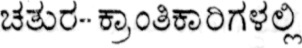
ಚತುರ-ಕ್ರಾಂತಿಕಾರಿಗಳಲ್ಲಿ
